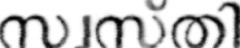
സ്വസ്തി
